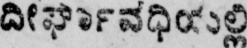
ದೀರ್ಘಾವಧಿಯಲ್ಲಿ
